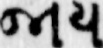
જાય
